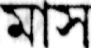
মাস
